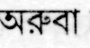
অরুবা
